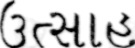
ઉત્સાહ
